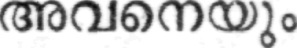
അവനെയും
